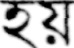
হয়
